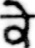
ਕੇ
